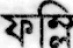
ফম্লি
